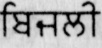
ਬਿਜਲੀ
